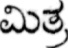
ಮಿತ್ರ
